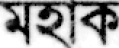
মহাক
